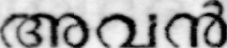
അവന്‍
